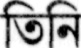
তিনি
